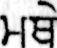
ਮਥੇ
